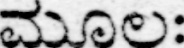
ಮೂಲ:
